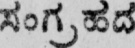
ಸಂಗ್ರಹದ
